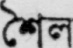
শৈল
